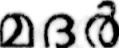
മദര്‍
